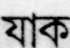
যাক
